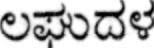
ಲಘುದಳ
